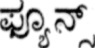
ಫ್ಯೂನ್ಸ್
